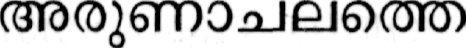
അരുണാചലത്തെ
